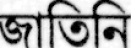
জাতিনি
